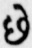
છે
